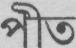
পীত
